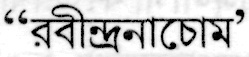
“রবীন্দ্রনাচোম’
